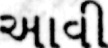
આવી
